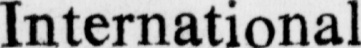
International
